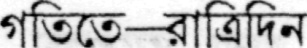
গতিতে—রাত্রিদিন
